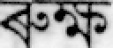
ৰুক্ষ
